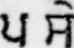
ਪਸੇ
